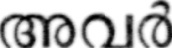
അവര്‍
